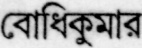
বোধিকুমার
